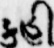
કહી
